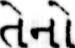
તેનો
